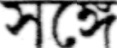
সঙ্গে
